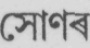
সোণৰ
